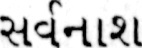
સર્વનાશ
